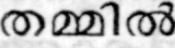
തമ്മില്‍
